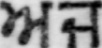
ਅਜ
